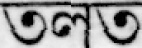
তলত
